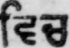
ਵਿਚ
